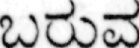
ಬರುವ
